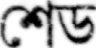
শেড
